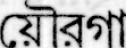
য়ৌরগা
